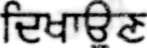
ਦਿਖਾਉਣ
